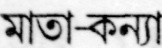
মাতা-কন্যা
